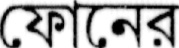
ফোনের
